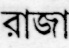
রাজা
